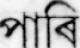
পাৰি
